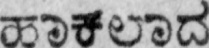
ಹಾಕಲಾದ
